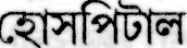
হোসপিটাল
